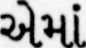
એમાં
